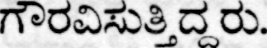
ಗೌರವಿಸುತ್ತಿದ್ದರು.
